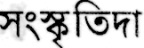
সংস্কৃতিদা
